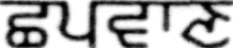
ਛਪਵਾਣ
